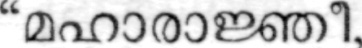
“മഹാരാജ്ഞീ,
